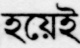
হয়েই
